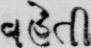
વહેતી
